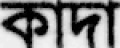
কাদা
